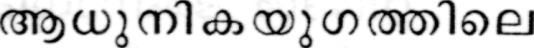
ആധുനികയുഗത്തിലെ
